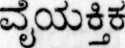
ವೈಯಕ್ತಿಕ
